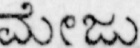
ಮೇಜು
